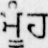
ਮੂੰਹ
